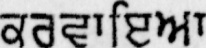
ਕਰਵਾਇਆ
